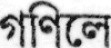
গণিলে
